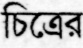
চিত্রের
